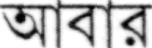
আবার
